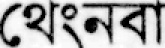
থেংনবা
